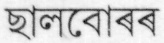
ছালবোৰৰ
